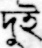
দুই
